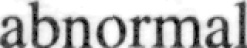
abnormal
